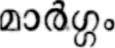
മാര്‍ഗ്ഗം
